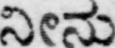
ನೀನು
